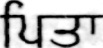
ਪਿਤਾ
